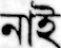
নাই
